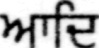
ਆਦਿ
